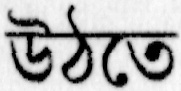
উঠতে
